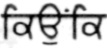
ਕਿਉਂਕਿ
